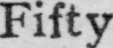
Fifty
